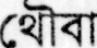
থৌবা
